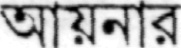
আয়নার
